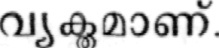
വ്യക്തമാണ്.
